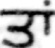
ਤਾਂ
